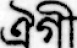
ঐগী
